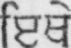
ਇਥੇ
